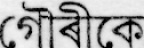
গৌৰীকে
